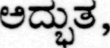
ಅದ್ಭುತ,
